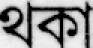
থকা
